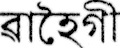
ৱাহৈগী
